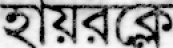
হায়রক্লে
